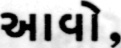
આવો,
